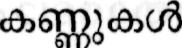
കണ്ണുകള്‍
